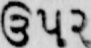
ઉપર
